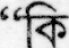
"কি
